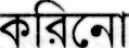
করিনো
